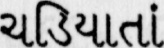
ચડિયાતાં
